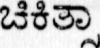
ಚಿಕಿತ್ಸಾ
